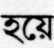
হয়ে
